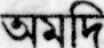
অমদি
